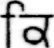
ਕਿ
